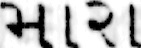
મારા
